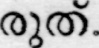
രുത്.
